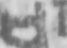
ਖਾ
